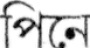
পিনে
